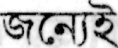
জন্যেই
